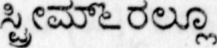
ಸ್ಟ್ರೀಮ್೬ರಲ್ಲೂ
